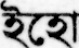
ইহো
